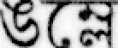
ঙম্লে
